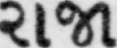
રાજા
